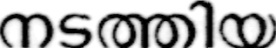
നടത്തിയ
